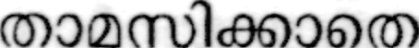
താമസിക്കാതെ
